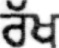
ਰੱਖ
